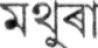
মথুৰা
